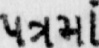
પત્રમાં
